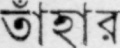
তাঁহার
